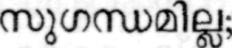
സുഗന്ധമില്ല;
